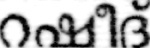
റഷീദ്
